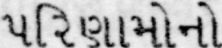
પરિણામોનો
